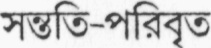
সন্ততি-পরিবৃত
